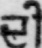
ਦੀ
